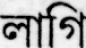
লাগি
